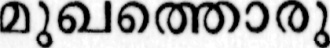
മുഖത്തൊരു
